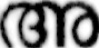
അ
